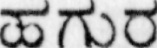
ಹಗುರ
